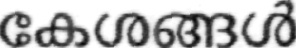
കേശങ്ങള്‍
